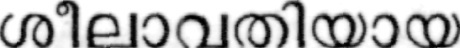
ശീലാവതിയായ
